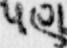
પણ
